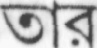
তার
